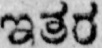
ಇತರ
